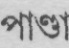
পাণ্ডা
